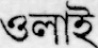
ওলাই
